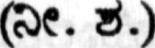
(ನೀ.ಶ.)
